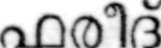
ഫരീദ്
